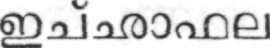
ഇച്ഛാഫല
